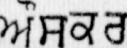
ਔਸਕਰ
